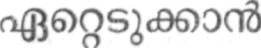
ഏറ്റെടുക്കാന്‍
